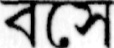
বসে
